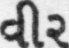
વીર
